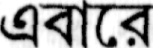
এবারে
